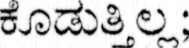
ಕೊಡುತ್ತಿಲ್ಲ;
